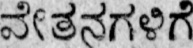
ವೇತನಗಳಿಗೆ
